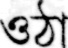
ওঠা
